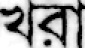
খরা
